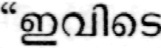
“ഇവിടെ
